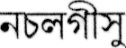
নচলগীসু
